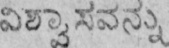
ವಿಶ್ವಾಸವನ್ನು
